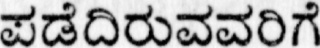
ಪಡೆದಿರುವವರಿಗೆ
